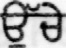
ਉੱਚੇ
